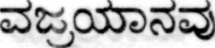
ವಜ್ರಯಾನವು
